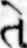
તે
